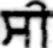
ਸੀ
